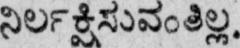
ನಿರ್ಲಕ್ಷಿಸುವಂತಿಲ್ಲ.
